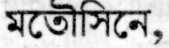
মতৌসিনে,
